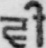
ਵੀ
